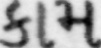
કામ
